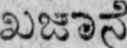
ಖಾಜಾನೆ
